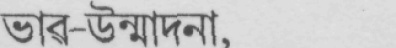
ভাৱ-উন্মাদনা,
